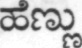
ಹೆಣ್ಣು
